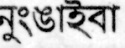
নুংঙাইবা
